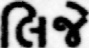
લિજે
